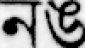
নঙ
